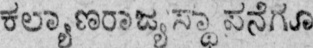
ಕಲ್ಯಾಣರಾಜ್ಯಸ್ಥಾಪನೆಗೂ
